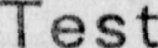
Test
